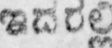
ಇದರಲ್ಲಿ
